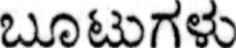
ಬೂಟುಗಳು
